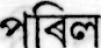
পৰিল
